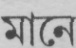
মানে
